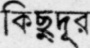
কিছুদূর
